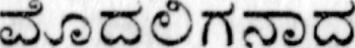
ಮೊದಲಿಗನಾದ
